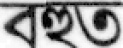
বহুত
